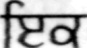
ਇਕ
